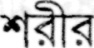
শরীর
